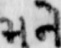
મને
